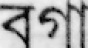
বগা
